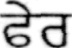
ਫੇਰ
